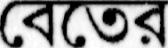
বেতের
